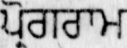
ਪ੍ਰੋਗਰਾਮ
